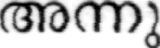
അന്നു
